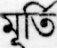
মূর্তি
